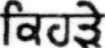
ਕਿਹੜੇ
